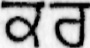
ਕਰ
